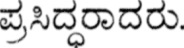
ಪ್ರಸಿದ್ಧರಾದರು.
